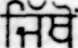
ਜਿੱਥੋਂ
